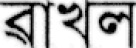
ৱাখল
